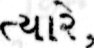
ત્યારે,
